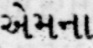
એમના
